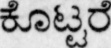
ಕೊಟ್ಟರೆ
